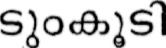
ടുംകൂടി
